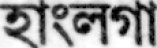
হাংলগা
